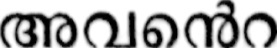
അവന്റെ
